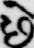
છે
